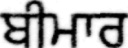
ਬੀਮਾਰ
